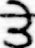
ਤੇ
